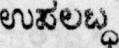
ಉಪಲಬ್ಧ
